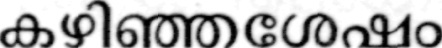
കഴിഞ്ഞശേഷം
